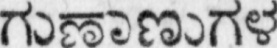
ಗುಣಾಣುಗಳ
